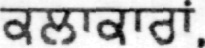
ਕਲਾਕਾਰਾਂ,
